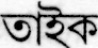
তাইক
